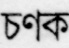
চণক
